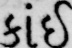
કાંઈ
